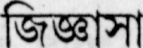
জিজ্ঞাসা
